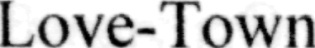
Love-Town
